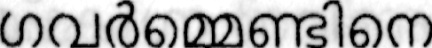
ഗവര്‍മ്മെണ്ടിനെ
